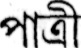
পাত্রী
